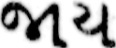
જાય
